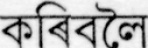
কৰিবলৈ
